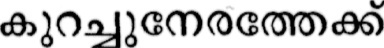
കുറച്ചുനേരത്തേക്ക്
